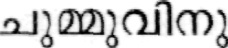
ചുമ്മുവിനു
